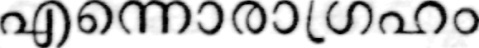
എന്നൊരാഗ്രഹം
